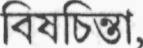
বিষচিন্তা,
